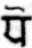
ਧੋ
